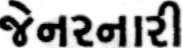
જેનરનારી
